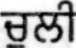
ਚੁਲੀ
